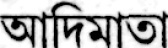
আদিমাতা
